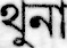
থুনা
